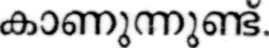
കാണുന്നുണ്ട്.
